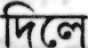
দিলে
